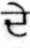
ਦੇ
